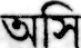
অসি
